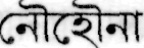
নৌহৌনা
